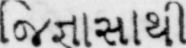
જિજ્ઞાસાથી
